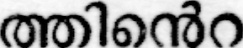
ത്തിന്റെ
